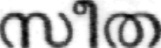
സീത
